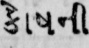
કોષની
